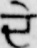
ਦੇ
